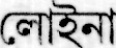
লোইনা
